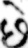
છે
